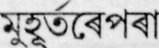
মুহূর্তৰেপৰা
